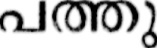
പത്തു
